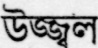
উজ্জ্বল
